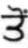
ਤੋਂ
